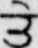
ਤੇ
